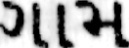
ગામ
